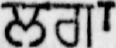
ਲਗਾ
